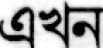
এখন
